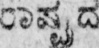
ರಾಷ್ಟ್ರದ
